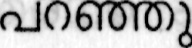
പറഞ്ഞു
